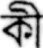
কী
